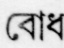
বোধ
